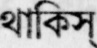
থাকিস্
